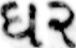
ઘર
